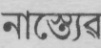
নাস্ত্যেৱ
